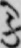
કે
